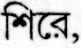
শিরে,
